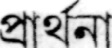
প্রার্থনা
